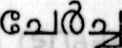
ചേര്‍ച്ച
